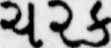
ચરક
